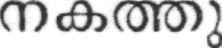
നകത്തു
